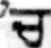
'ਚ
